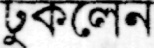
ঢুকলেন
